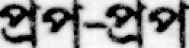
প্রপ-প্রপ
